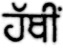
ਹੱਥੀਂ
